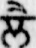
ਲੈ
